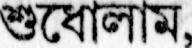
শুধোলাম,
